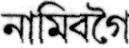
নামিবগৈ
